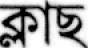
ক্লাছ
